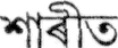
শাৰীত
